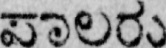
ಪಾಲರು
